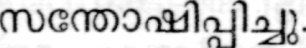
സന്തോഷിപ്പിച്ചു.
